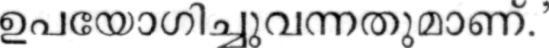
ഉപയോഗിച്ചുവന്നതുമാണ്.’
